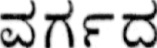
ವರ್ಗದ
